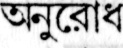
অনুরোধ
